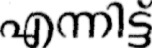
എന്നിട്ട്
